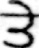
ਤੇ
